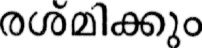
രശ്മിക്കും
